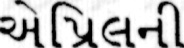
એપ્રિલની
